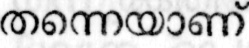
തന്നെയാണ്
